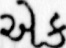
એક
